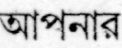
আপনার
